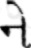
ને
